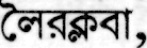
লৈরক্লবা,
